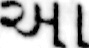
આ
